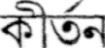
কীর্তন
